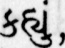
કહ્યું,
